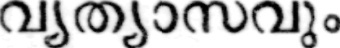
വ്യത്യാസവും
